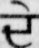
ਦੇ
